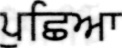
ਪੁਛਿਆ
